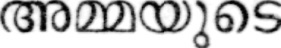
അമ്മയുടെ
